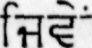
ਜਿਵੇਂ
